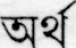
অর্থ
